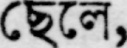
ছেলে,
